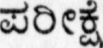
ಪರೀಕ್ಷೆ
